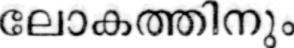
ലോകത്തിനും
